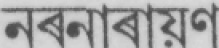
নৰনাৰায়ণ
